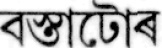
বস্তাটোৰ
